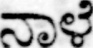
ನಾಳೆ
